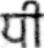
ਧੀ
